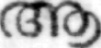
ആ
